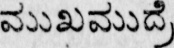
ಮುಖಮುದ್ರೆ
